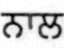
ਨਾਲ
